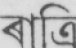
ৰাত্রি
